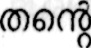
തന്റെ
